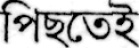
পিছতেই
